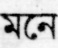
মনে
